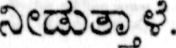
ನೀಡುತ್ತಾಳೆ.
